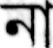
না
